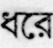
ধরে
